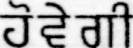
ਹੋਵੇਗੀ
